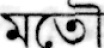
মতৌ
